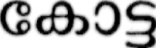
കോട്ട
